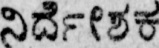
ನಿರ್ದೇಶಕ
